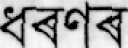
ধৰণৰ
